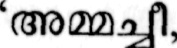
‘അമ്മച്ചീ,
